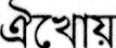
ঐখোয়
